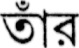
তাঁর
